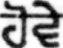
ਹੋਵੇ
